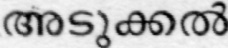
അടുക്കല്‍
